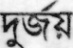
দুর্জয়
